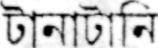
টানাটানি
